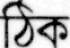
ঠিক
